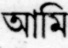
আমি
